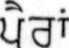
ਪੈਰਾਂ
